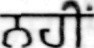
ਨਹੀਂ
